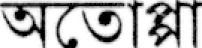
অতোপ্পা
